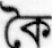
কৈ
